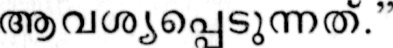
ആവശ്യപ്പെടുന്നത്.”
